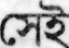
সেই
